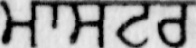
ਮਾਸਟਰ
